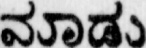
ಮಾಡು
